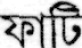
ফাটি
